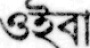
ওইবা
